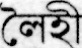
লৈহী
